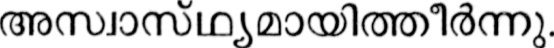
അസ്വാസ്ഥ്യമായിത്തീര്‍ന്നു.
